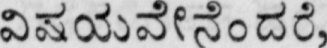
ವಿಷಯವೇನೆಂದರೆ,
